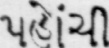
પહોંચી
